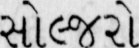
સોલ્જરો
